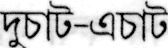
দুচাট-এচাট
